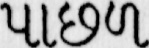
પાછળ
